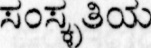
ಸಂಸ್ಕೃತಿಯ
